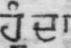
ਹੁੰਦਾ
